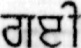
ਗਈ
